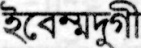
ইবেম্মদুগী
